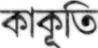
কাকূতি
